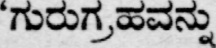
‘ಗುರುಗ್ರಹವನ್ನು
